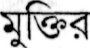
মুক্তির
